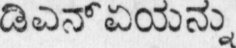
ಡಿಎನ್‌ಎಯನ್ನು
